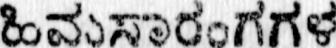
ಹಿಮಸಾರಂಗಗಳ
